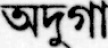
অদুগা
